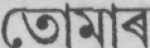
তোমাৰ
